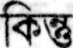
কিন্তু
